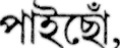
পাইছোঁ,
